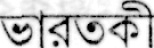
ভারতকী
